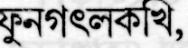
ফুনগৎলকখি,
